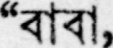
‘‘বাবা,
